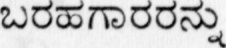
ಬರಹಗಾರರನ್ನು
